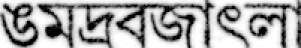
ঙমদ্রবজাৎলা
